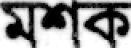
মশক
